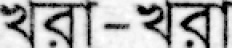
খরা-খরা
